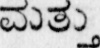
ಮತ್ತು
